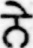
ਨੇ
